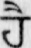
ਹੈ
